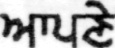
ਆਪਣੇ
